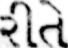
રીતે
